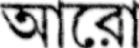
আরো
